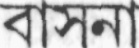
বাসনা
